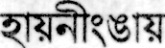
হায়নীংঙাই
